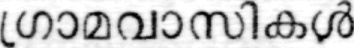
ഗ്രാമവാസികള്‍
